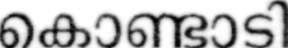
കൊണ്ടാടി
